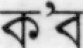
ক'ব
